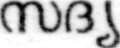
സദ്യ
